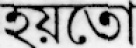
হয়তো
